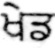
ਖੇਡ
